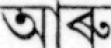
আৰু
